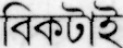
বিকটাই
